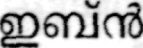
ഇബ്ന്‍
